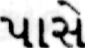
પાસે
